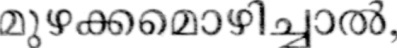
മുഴക്കമൊഴിച്ചാല്‍,
